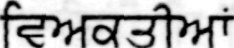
ਵਿਅਕਤੀਆਂ
